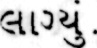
લાગ્યું.
